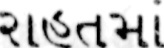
રાહતમાં
